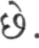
છે.
